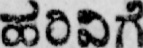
ಹರಿವಿಗೆ
